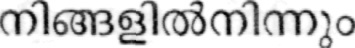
നിങ്ങളില്‍നിന്നും
